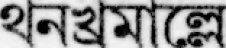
থনখ্রমাল্লে
